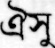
ঐসু
